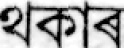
থকাৰ
